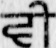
ਵੀ
